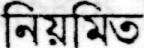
নিয়মিত
